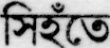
সিহঁতে
